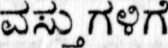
ವಸ್ತುಗಳಿಗೆ
